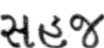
સહજ
